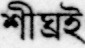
শীঘ্রই
